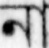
না
